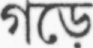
গড়ে
